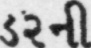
ડરની
